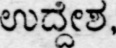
ಉದ್ದೇಶ,
